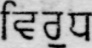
ਵਿਰੁਧ
